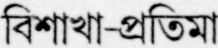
বিশাখা-প্রতিমা
